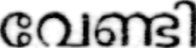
വേണ്ടി
